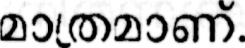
മാത്രമാണ്.
